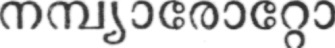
നമ്പ്യാരോറ്റോ
